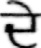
ਦੇ
